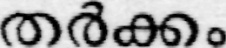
തര്‍ക്കം
